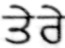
ਤੇਰੇ
